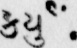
કર્યું.
